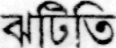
ঝটিতি
